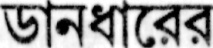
ডানধারের
